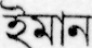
ইমান
